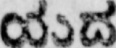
ಯದ
